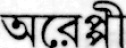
অরেপ্পী
